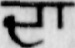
ਦਾ
